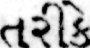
તરીકે
